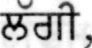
ਲੱਗੀ,
